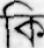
কি
